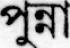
পুন্না
